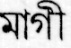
মাগী
